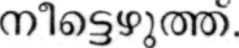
നീട്ടെഴുത്ത്.
